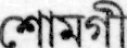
শোমগী
